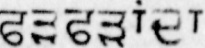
ਫੜਫੜਾਂਦਾ
